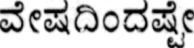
ವೇಷದಿಂದಷ್ಟೇ
